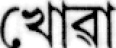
খোৱা
